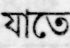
যাতে
